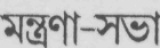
মন্ত্ৰণা-সভা
